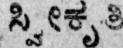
ಸ್ವೀಕೃತಿ
